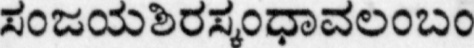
ಸಂಜಯಶಿರಸ್ಕಂಧಾವಲಂಬಂ
